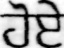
ਹੋਏ
